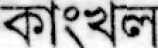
কাংখল
